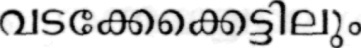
വടക്കേക്കെട്ടിലും
